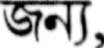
জন্য,
